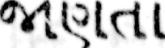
જાણતા
